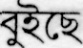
বুইছে
